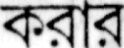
করার
